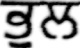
ਭੁਲ
